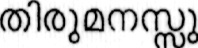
തിരുമനസ്സു
